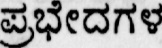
ಪ್ರಭೇದಗಳ
